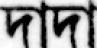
দাদা
